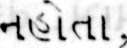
નહોતા,
